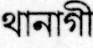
থানাগী
